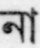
না
